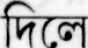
দিলে
